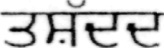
ਤਸ਼ੱਦਦ
